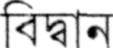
বিদ্বান
